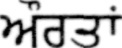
ਔਰਤਾਂ
